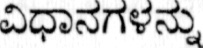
ವಿಧಾನಗಳನ್ನು
